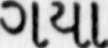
ગયા
